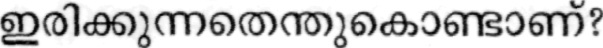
ഇരിക്കുന്നതെന്തുകൊണ്ടാണ്?
